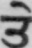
ਤੇ
